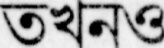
তখনও
